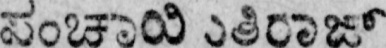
ಪಂಚಾಯಿತಿರಾಜ್
